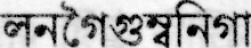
লনগৈগুম্বনিগা
